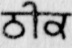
ਠੀਕ
